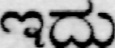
ಇದು
